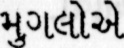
મુગલોએ
